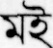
মই
